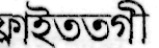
ফ্লাইততগী
